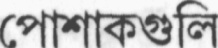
পোশাকগুলি
